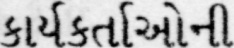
કાર્યકર્તાઓની
